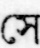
সে
